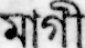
মাগী
